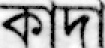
কাদা
